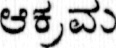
ಆಕ್ರಮ
